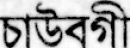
চাউবগী
